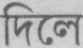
দিলে
